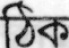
ঠিক
